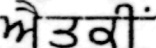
ਐਤਕੀਂ
